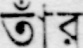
তাঁর
